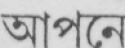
আপনে
